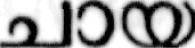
ചായ
